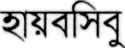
হায়বসিবু
